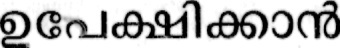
ഉപേക്ഷിക്കാന്‍
